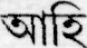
আহি
